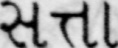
સત્તા
